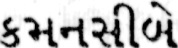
કમનસીબે
